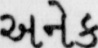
અનેક
